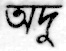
অদু
